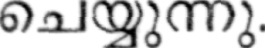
ചെയ്യുന്നു.
